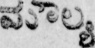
ಮೌಲ್ಯ
